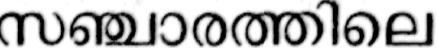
സഞ്ചാരത്തിലെ
